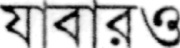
যাবারও
